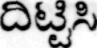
ದಿಟ್ಟಿಸಿ
